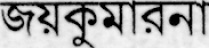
জয়কুমারনা
